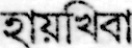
হায়খিবা
